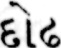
દોઢ
